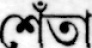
শেঁতা
